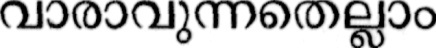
വാരാവുന്നതെല്ലാം
